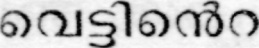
വെട്ടിന്റെ
